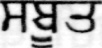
ਸਬੂਤ
